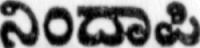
ನಿಂದಾಪಿ
